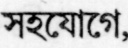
সহযোগে,
